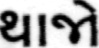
થાજો
